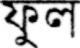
ফুল
